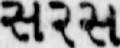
સરસ
